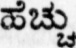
ಹೆಚ್ಚು
